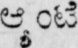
ಆಂಟೆ
